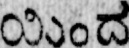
ಯಿಂದ
